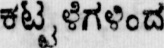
ಕಟ್ಟಳೆಗಳಿಂದ
